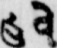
હવે
